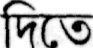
দিতে
